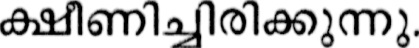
ക്ഷീണിച്ചിരിക്കുന്നു.
